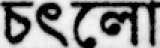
চৎলো
